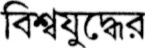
বিশ্বযুদ্ধের
